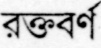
রক্তবর্ণ
